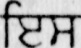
ਇਸ
